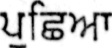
ਪੁਛਿਆ
